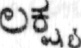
ಲಕ್ಷ್ಯ
